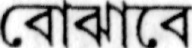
বোঝাবে
